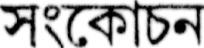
সংকোচন
